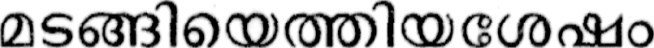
മടങ്ങിയെത്തിയശേഷം
